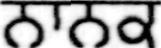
ਨਾਨਕ
